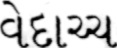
વેદાચ્ચ
